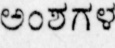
ಅಂಶಗಳ
